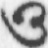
ও
